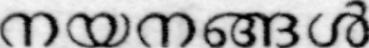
നയനങ്ങള്‍
